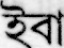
ইবা
